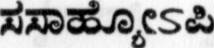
ಸಸಾಹ್ಯೋsಪಿ
